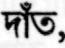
দাঁত,
